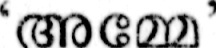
'അമ്മേ'
